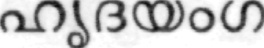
ഹൃദയംഗ
